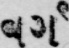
વર્ગ
